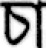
চা
